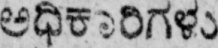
ಅಧಿಕಾರಿಗಳು
